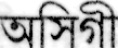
অসিগী
